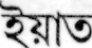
ইয়াত
